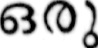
ഒരു
